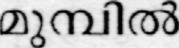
മുമ്പില്‍
